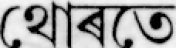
থোৰতে
